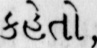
કહેતો,
